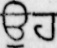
ਉਹ
